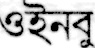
ওইনবু
